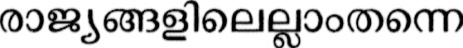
രാജ്യങ്ങളിലെല്ലാംതന്നെ
